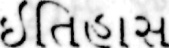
ઈતિહાસ
